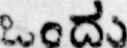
ಒಂದು
